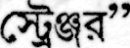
স্ট্রেঞ্জর”
